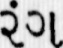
રંગ
